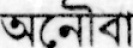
অনৌবা
